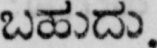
ಬಹುದು.
